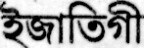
ইজিতিগী
